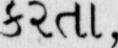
કરતા,
